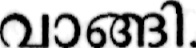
വാങ്ങി.
